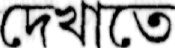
দেখাতে
